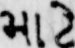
માટે
